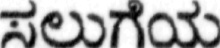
ಸಲುಗೆಯ
